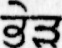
ਭੇੜ
